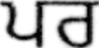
ਪਰ
